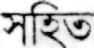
সহিত
